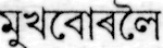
মুখবোৰলৈ
